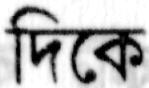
দিকে
